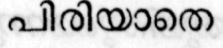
പിരിയാതെ
